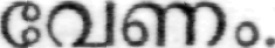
വേണം.
